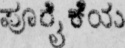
ಪೂರೈಕೆಯ
